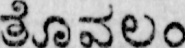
ತೊವಲಂ
